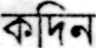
কদিন
